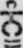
ਨੂੰ
